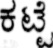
ಕಟ್ಟೆ
